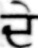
ਦੇ
